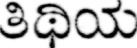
ತಿಥಿಯ
